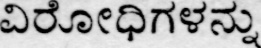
ವಿರೋಧಿಗಳನ್ನು
